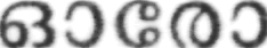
ഓരോ
